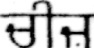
ਚੀਜ਼
